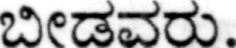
ಬೀಡವರು.
